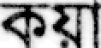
কয়া
